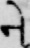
ને
